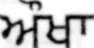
ਔਖਾ
